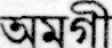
অমগী
